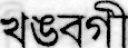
খঙবগী
